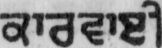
ਕਾਰਵਾਈ
